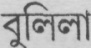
বুলিলা
